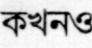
কখনও
